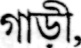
গাড়ী,
